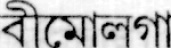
বীমোলগা
